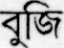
বুজি
